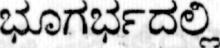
ಭೂಗರ್ಭದಲ್ಲಿ
